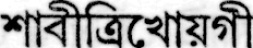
শাবীত্রিখোয়গী
